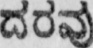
ದರವು
